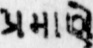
પ્રમાણે
